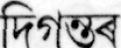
দিগন্তৰ
